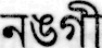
নঙগী
